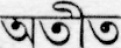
অতীত
